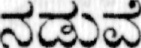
ನಡುವೆ
